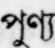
পুণ্য
